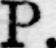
P.
